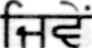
ਜਿਵੇਂ
